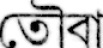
তৌবা
